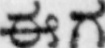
ಈಗ
